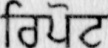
ਰਿਪੋਟ
